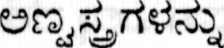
ಅಣ್ವಸ್ತ್ರಗಳನ್ನು
